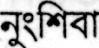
নুংশিবা
